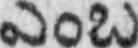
ಎಂಬ
